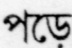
পড়ে
